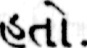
હતો.
